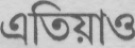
এতিয়াও
